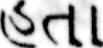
હતા
